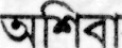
অশিবা
